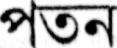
পতন
